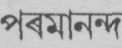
পৰমানন্দ
